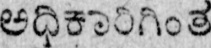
ಅಧಿಕಾರಿಗಿಂತ
